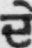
ਦੇ
